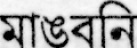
মাঙবনি
